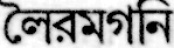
লৈরমগনি
